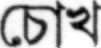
চোখ
